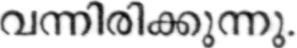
വന്നിരിക്കുന്നു.
